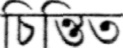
চিন্তিত
